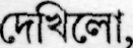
দেখিলো,
